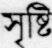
সৃষ্টি
